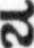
ನ
